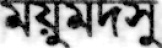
ময়ুমদসু
